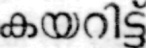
കയറിട്ട്
